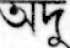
অদু
